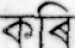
কৰি
